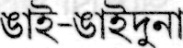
ঙাই-ঙাইদুনা
